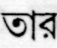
তার
